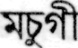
মচুগী
